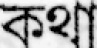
কথা
